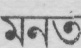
মনত
